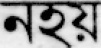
নহয়
